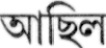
আছিল
